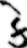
કે
